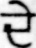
ਦੇ
